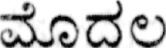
ಮೊದಲ
